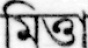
মিত্তা
